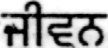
ਜੀਵਨ
